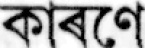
কাৰণে
